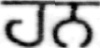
ਹਨ
